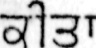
ਕੀਤਾ
